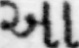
આ
